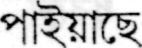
পাইয়াছে
